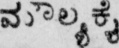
ಮೌಲ್ಯಕ್ಕೆ
